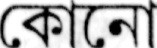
কোনো
